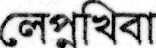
লেপ্নখিবা
